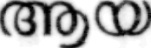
ആയ
